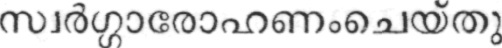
സ്വര്‍ഗ്ഗാരോഹണംചെയ്തു
